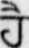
ਹੈ
